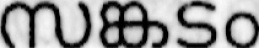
സങ്കടം
